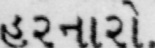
હરનારો.
